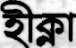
হীক্ন
